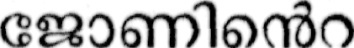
ജോണിന്റെ
